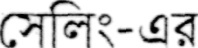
সেলিং-এর
